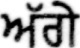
ਅੱਗੇ
